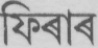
ফিৰাৰ
